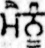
ਮੈਨੂੰ
